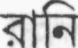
রানি
